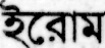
ইরোম
